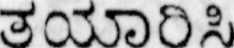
ತಯಾರಿಸಿ
